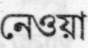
নেওয়া
